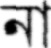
না
